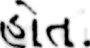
હોત.
